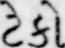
ટેકો
